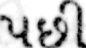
પછી
